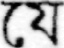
যে
